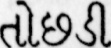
તોછડી
